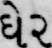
ઘેર
